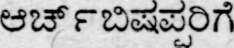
ಆರ್ಚ್‌ಬಿಷಪ್ಪರಿಗೆ
